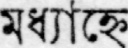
মধ্যাহ্নে
